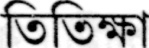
তিতিক্ষা
